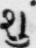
શું
